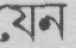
যেন
